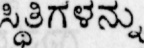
ಸ್ಥಿತಿಗಳನ್ನು
